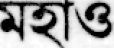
মহাও
